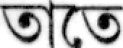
তাতে
